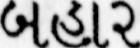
બહાર
